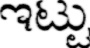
ಇಟ್ಟು
